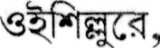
ওইশিল্লুরে,
